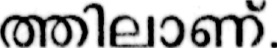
ത്തിലാണ്.
